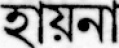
হায়না
